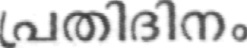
പ്രതിദിനം
